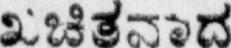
ಖಚಿತವಾದ
